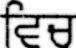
ਵਿਚ
